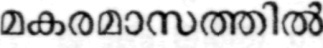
മകരമാസത്തില്‍
